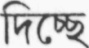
দিচ্ছে
